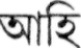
আহি
